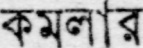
কমলার
